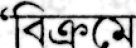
'বিক্রমে
